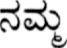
ನಮ್ಮ
